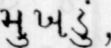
મુખડું,
